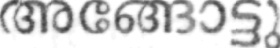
അങ്ങോട്ടു
